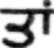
ਤਾਂ
